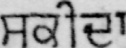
ਸਕੀਦਾ
